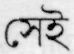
সেই
